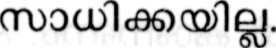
സാധിക്കയില്ല.
